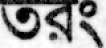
তরং
